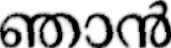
ഞാന്‍
